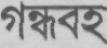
গন্ধবহ
